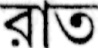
রাত
